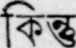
কিন্তু
